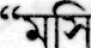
“মসি
